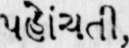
પહોંચતી,
